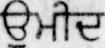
ਉਮੀਦ
